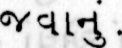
જવાનું.
